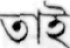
তাই
